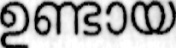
ഉണ്ടായ
